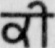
ਕੀ
